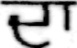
ਦਾ
